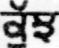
ਕੁੱਝ
